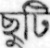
ছুটি
